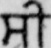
ਸੀ
